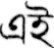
এই
